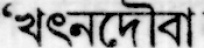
“খৎনদৌবা
